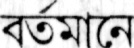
বর্তমানে
